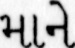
માને
